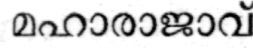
മഹാരാജാവ്
